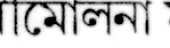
বীমোলনা
